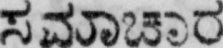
ಸಮಾಚಾರ
